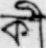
কী
